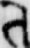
તે
